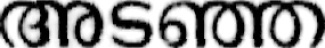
അടഞ്ഞ
